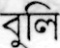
বুলি
